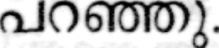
പറഞ്ഞു.
